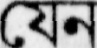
যেন
